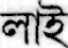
লাই
